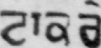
ਟਾਕਰੇ
